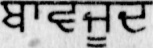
ਬਾਵਜੂਦ
